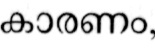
കാരണം,
